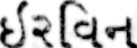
ઇરવિન
